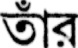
তাঁর
